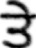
ਤੇ
